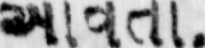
આવતા.
